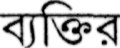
ব্যক্তির
